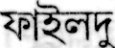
ফাইলদু
